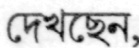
দেখছেন,
